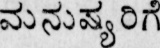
ಮನುಷ್ಯರಿಗೆ
